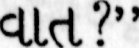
વાત?"
